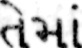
તેમાં
